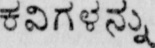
ಕವಿಗಳನ್ನು
